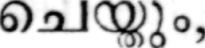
ചെയ്തും,
